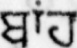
ਬਾਂਹ
